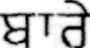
ਬਾਰੇ
